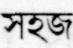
সহজ
